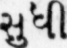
સુધી
